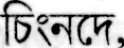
চিংনদে,
